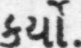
કર્યો.
